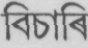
বিচাৰি
